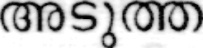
അടുത്ത
